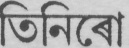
তিনিৰো
